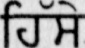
ਹਿੱਸੇ
